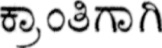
ಕ್ರಾಂತಿಗಾಗಿ
